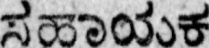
ಸಹಾಯಕ
